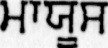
ਮਾਯੂਸ
